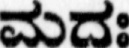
ಮದಃ
